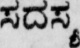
ಸದಸ್ಯ
